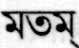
মতম্
